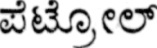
ಪೆಟ್ರೋಲ್
